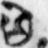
છે.
